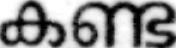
കണ്ട
